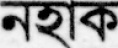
নহাক
